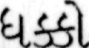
ધક્કો
